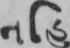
નહિ
